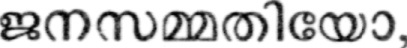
ജനസമ്മതിയോ,
